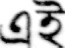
এই
